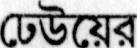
ঢেউয়ের
